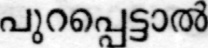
പുറപ്പെട്ടാല്‍
